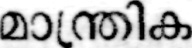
മാന്ത്രിക
